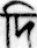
দি
